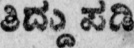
ತಿದ್ದುಪಡಿ
